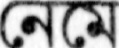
নেমে
